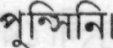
পুন্সিনি।
